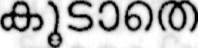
കൂടാതെ
